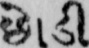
છોડી
